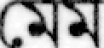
মেম
